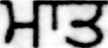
ਮਾਤ
